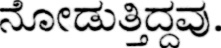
ನೋಡುತ್ತಿದ್ದವು.
